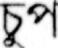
চুপ
